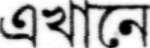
এখানে
